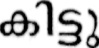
കിട്ടു
